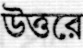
উত্তরে
